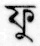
ফু
